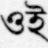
ওই
